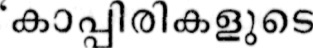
‘കാപ്പിരികളുടെ
